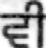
ਵੀ
